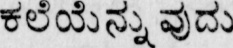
ಕಲೆಯೆನ್ನುವುದು
